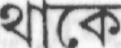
থাকে
